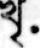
খৃ.
